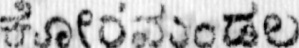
ಕೋರಮಂಡಲ
